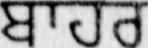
ਬਾਹਰ
